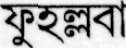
ফুহল্লবা
